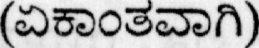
(ಏಕಾಂತವಾಗಿ)
